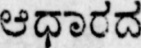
ಆಧಾರದ
